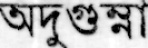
অদুগুম্না
